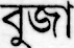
বুজা
